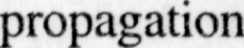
propagation
